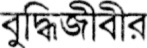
বুদ্ধিজীবীর
